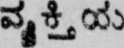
ವ್ಯಕ್ತಿಯ
